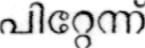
പിറ്റേന്ന്
